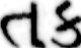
તક
